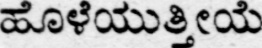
ಹೊಳೆಯುತ್ತೀಯೆ
